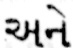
અને
